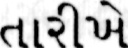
તારીખે
